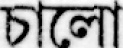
চালো
